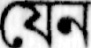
যেন
